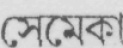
সেমেকা
